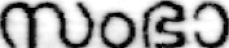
സംഭാ
